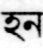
হন
